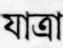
যাত্রা
